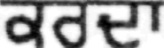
ਕਰਦਾ
